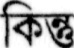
কিন্তু
